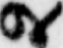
જ
